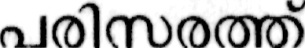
പരിസരത്ത്
